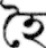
হৈ
